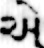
એ
